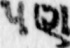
પણ
